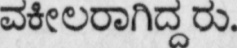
ವಕೀಲರಾಗಿದ್ದರು.
